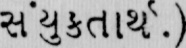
સંયુક્તાર્થ.)
